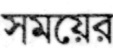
সময়ের
